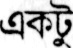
একটু
